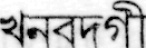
খনবদগী
